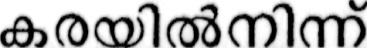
കരയില്‍നിന്ന്
